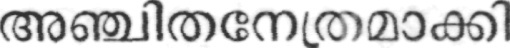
അഞ്ചിതനേത്രമാക്കി
